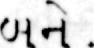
બને.
